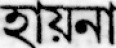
হায়না
